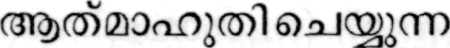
ആത്മാഹുതിചെയ്യുന്ന
